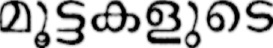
മൂട്ടകളുടെ
